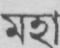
মহা
